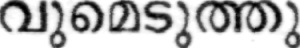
വുമെടുത്തു
